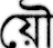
য়ৌ
